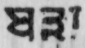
ਬੜਾ
